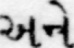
અને
